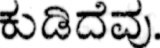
ಕುಡಿದೆವು.
